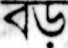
বড়
